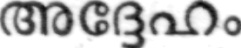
അദ്ദേഹം
